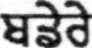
ਬਡੇਰੇ
